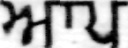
ਆਪ
